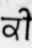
ਕੀ
